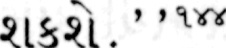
શકશે."૧૪૪
